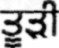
ਤੂੜੀ
